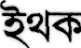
ইথক
